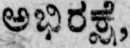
ಅಭಿರಕ್ಷೆ,
